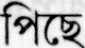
পিছে
